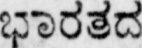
ಭಾರತದ
